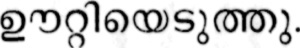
ഊറ്റിയെടുത്തു.
